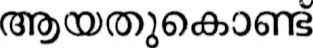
ആയതുകൊണ്ട്
